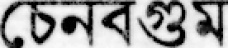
চেনবগুম
